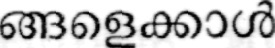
ങ്ങളെക്കാള്‍
